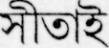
সীতাই
